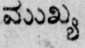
ಮುಖ್ಯ
